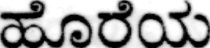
ಹೊರೆಯ
